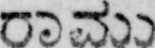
ರಾಮು
